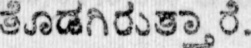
ತೊಡಗಿರುತ್ತಾರೆ.
